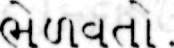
ભેળવતો.
